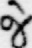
જે
